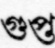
গুপ্ত
